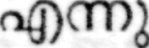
എന്നു
